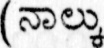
(ನಾಲ್ಕು
